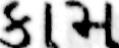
કામ
